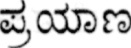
ಪ್ರಯಾಣ
